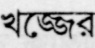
খজ্জের
